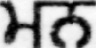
ਮਨ
